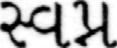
સ્વપ્ન
